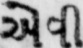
એવી
